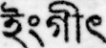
ইংগীৎ
